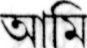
আমি
